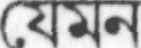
যেমন
